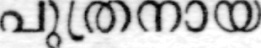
പുത്രനായ
